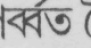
পৰ্ব্বত
